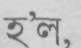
হ'ল,
